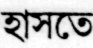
হাসতে
